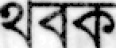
থবক
